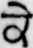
ਕੇ
